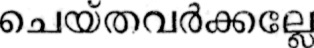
ചെയ്തവര്‍ക്കല്ലേ
